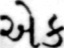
એક
